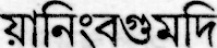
য়ানিংবগুমদি
